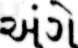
અંગે
